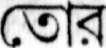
তোর
